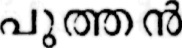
പുത്തന്‍
